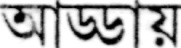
আড্ডায়
